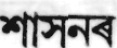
শাসনৰ
